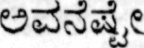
ಅವನೆಷ್ಟೇ
